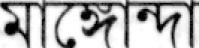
মাঙ্গোন্দা
